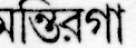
মন্তিরগা
